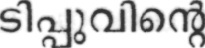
ടിപ്പുവിന്റെ
